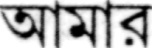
আমার
